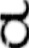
ರ
